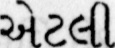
એટલી
